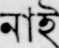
নাই
